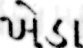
ખેડા
